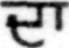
ਦਾ
